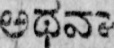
ಅಥವಾ
